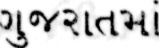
ગુજરાતમાં
